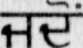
ਜਦੋਂ
